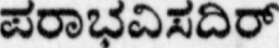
ಪರಾಭವಿಸದಿರ್
